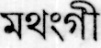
মথংগী
